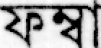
ফম্বা
